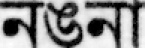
নঙনা
